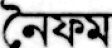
নৈফম
